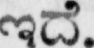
ಇದೆ.
